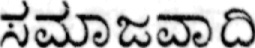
ಸಮಾಜವಾದಿ
